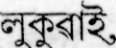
লুকুৱাই,
